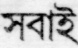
সবাই
